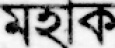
মহাক
